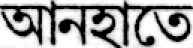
আনহাতে
